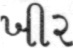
ખીર
